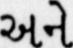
અને
